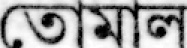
তোমাল
